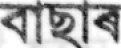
বাছাৰ
